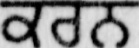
ਕਰਨ
